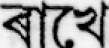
ৰাখে
